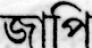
জাপি
